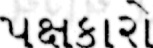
પક્ષકારો
